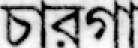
চারগা
